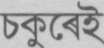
চকুৰেই
